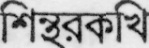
শিন্থরকখি
